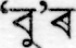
'বু'ৰ
